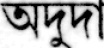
অদুদা
